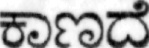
ಕಾಣದೆ
